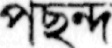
পছন্দ
